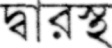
দ্বারস্থ
